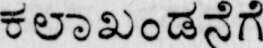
ಕಲಾಖಂಡನೆಗೆ
